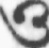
ও
